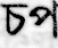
চপ
